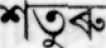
শতুৰু
